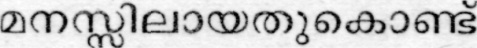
മനസ്സിലായതുകൊണ്ട്
